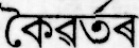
কৈৱর্তৰ
